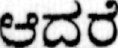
ಆದರೆ
